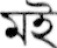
মই
